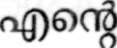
എന്റെ
